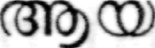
ആയ
